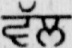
ਵੱਲ
